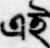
এই
